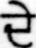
ਦੇ
